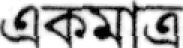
একমাত্র
